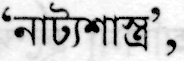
‘নাট্যশাস্ত্র’,
